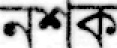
নশক
